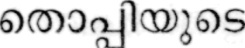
തൊപ്പിയുടെ
